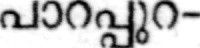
പാറപ്പുറ-
